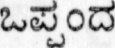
ಒಪ್ಪಂದ
